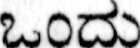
ಒಂದು
